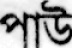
পাউ
